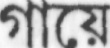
গায়ে
